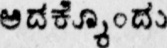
ಅದಕ್ಕೊಂದು
